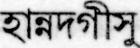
হান্নদগীসু
